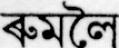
ৰুমলৈ
